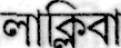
লাক্লিবা
